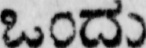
ಒಂದು
